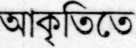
আকৃতিতে
